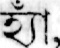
হ্যাঁ,
